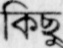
কিছু
